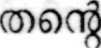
തന്റെ
